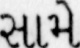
સામે
